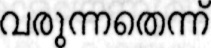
വരുന്നതെന്ന്
